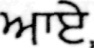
ਆਏ,
